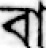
বা
